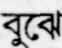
বুঝে
